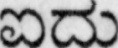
ಐದು
